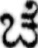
ಚೆ
